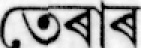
তেৰাৰ
